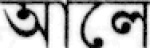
আলে
